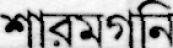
শারমগনি
